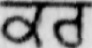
ਕਰ
